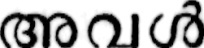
അവള്‍
